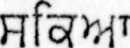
ਸਕਿਆ
